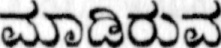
ಮಾಡಿರುವ
